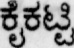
ಕೈಕಟ್ಟಿ
